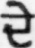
ਦੇ
